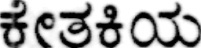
ಕೇತಕಿಯ
